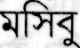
মসিবু
